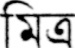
মিত্র
